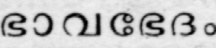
ഭാവഭേദം
